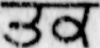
ਤਕ
